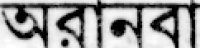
অরানবা
